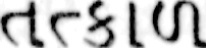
તત્કાળ
